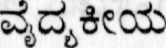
ವೈದ್ಯಕೀಯ
